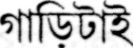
গাড়িটাই
